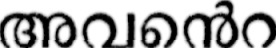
അവന്റെ
